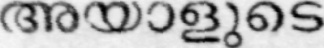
അയാളുടെ
